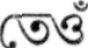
তেওঁ
